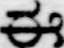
ಈ
